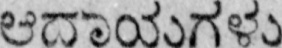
ಆದಾಯಗಳು
